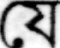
যে
